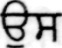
ਉਸ
